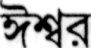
ঈশ্বর
